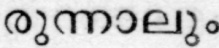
രുന്നാലും
